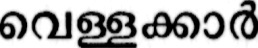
വെള്ളക്കാര്‍
